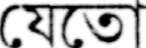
যেতো
